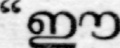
"ഈ
